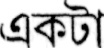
একটা
